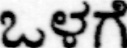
ಒಳಗೆ
